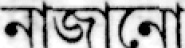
নাজানো
